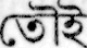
তৌই
